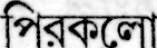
পিরকলো
